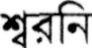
শ্বরনি
